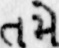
તમે
